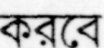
করবে
